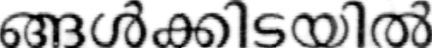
ങ്ങള്‍ക്കിടയില്‍
